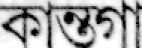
কান্তগা
